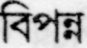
বিপন্ন
